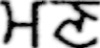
ਮਣ
